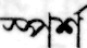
স্পৰ্শ
